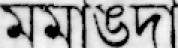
মমাঙদা
